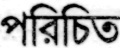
পরিচিত
